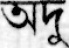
অদু
